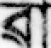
ৱা
